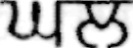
ਘਲ
